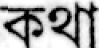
কথা
